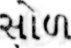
સોળ
